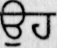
ਉਹ
